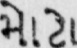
મોટો
